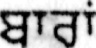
ਬਾਰਾਂ
